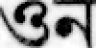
ওন
